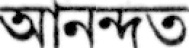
আনন্দত
